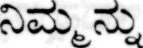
ನಿಮ್ಮನ್ನು
